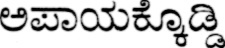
ಅಪಾಯಕ್ಕೊಡ್ಡಿ
